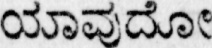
ಯಾವುದೋ
